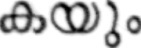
കയും
